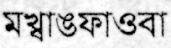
মখ্বাঙফাওবা
